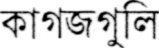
কাগজগুলি
